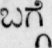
ಬಗ್ಗೆ
